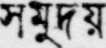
সমুদয়
